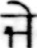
ਜੇ
